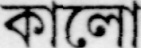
কালো
